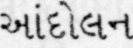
આંદોલન
